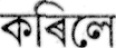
কৰিলে
